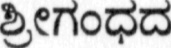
ಶ್ರೀಗಂಧದ
